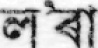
ল'ৰা
